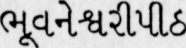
ભૂવનેશ્વરીપીઠ
